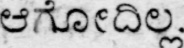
ಆಗೋದಿಲ್ಲ.
